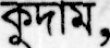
কুদাম,
